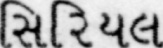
સિરિયલ
